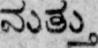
ಮತ್ತು
